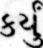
કર્યું
